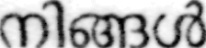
നിങ്ങള്‍
